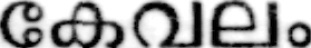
കേവലം
